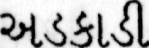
અડકાડી
